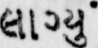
લાગ્યું
